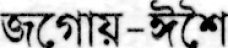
জগোয়-ঈশৈ
